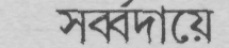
সৰ্ব্বদায়ে
